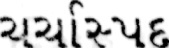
ચર્ચાસ્પદ
